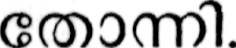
തോന്നി.
